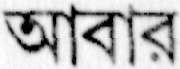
আবার
